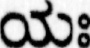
ಯಃ
